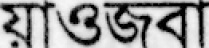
য়াওজবা
